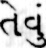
તેવું
